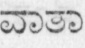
ವಾತಾ
